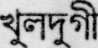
খুলদুগী
